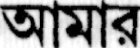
আমার
